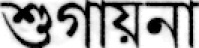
শুগায়না
